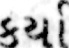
કર્યા
